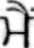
ਮੈਂ
